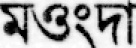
মওংদা
